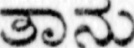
ತಾನು
